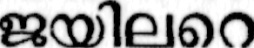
ജയിലറെ
